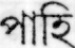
পাহি
